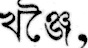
খঞ্জৈ,
